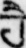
ਹੈ
